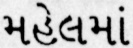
મહેલમાં
